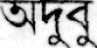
অদুবু
